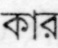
কার
